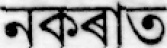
নকৰাত
